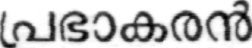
പ്രഭാകരന്‍
